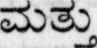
ಮತ್ತು
